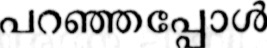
പറഞ്ഞപ്പോള്‍
